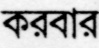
করবার
